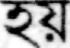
হয়
